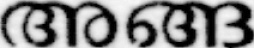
അങ്ങ
